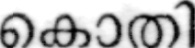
കൊതി
